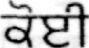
ਕੋਈ
